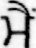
ਮੈਂ
